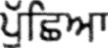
ਪੁੱਛਿਆ
